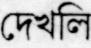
দেখলি
